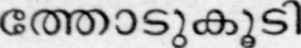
ത്തോടുകൂടി
